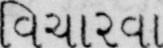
વિચારવા
